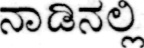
ನಾಡಿನಲ್ಲಿ
